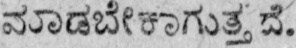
ಮಾಡಬೇಕಾಗುತ್ತದೆ.
